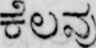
ಕೆಲವು
